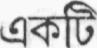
একটি
